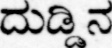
ದುಡ್ಡಿನ
